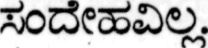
ಸಂದೇಹವಿಲ್ಲ.
